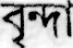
বৃন্দা
